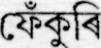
ফেঁকুৰি
